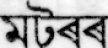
মটৰৰ
